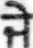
ਜੇ
